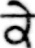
ਕੇ
